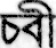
চবী
